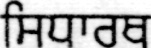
ਸਿਧਾਰਥ
